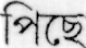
পিছে
